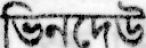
ভিনদেউ
